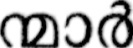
ന്മാര്‍
